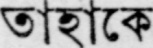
তাহাকে
